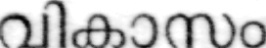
വികാസം
